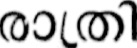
രാത്രി
